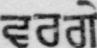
ਵਰਗੇ
